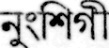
নুংশিগী
